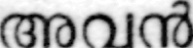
അവന്‍
